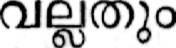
വല്ലതും
